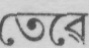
তেৱে
